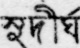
সুদীর্ঘ
